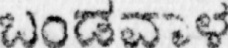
ಬಂಡವಾಳ
